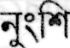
নুংশি
